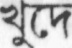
খুদে
